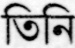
তিনি
